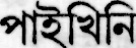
পাইখিনি
